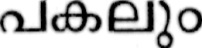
പകലും
